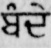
ਬੰਦੇ
